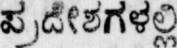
ಪ್ರದೇಶಗಳಲ್ಲಿ
